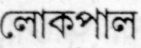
লোকপাল
